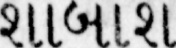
શાબાશ
